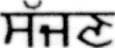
ਸੱਜਣ
